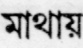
মাথায়
